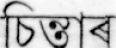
চিন্তাৰ
